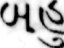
બહુ
